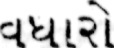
વધારો
